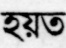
হয়ত
